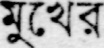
মুখের
